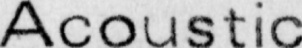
Acoustic
